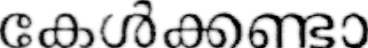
കേള്‍ക്കണ്ടാ
